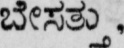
ಬೇಸತ್ತು,
